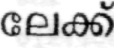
ലേക്ക്
